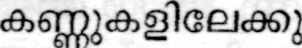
കണ്ണുകളിലേക്കു
